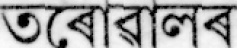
তৰোৱালৰ
